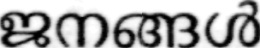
ജനങ്ങള്‍
